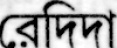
রেদিদা
